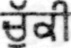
ਚੁੱਕੀ
